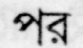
পর
